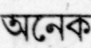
অনেক
